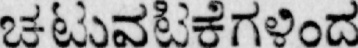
ಚಟುವಟಿಕೆಗಳಿಂದ
